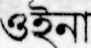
ওইনা
